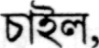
চাইল,
